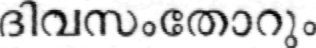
ദിവസംതോറും
